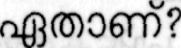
ഏതാണ്?
